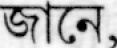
জানে,
